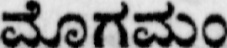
ಮೊಗಮಂ
